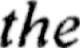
the
